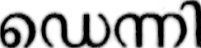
ഡെന്നി
